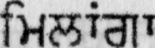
ਮਿਲਾਂਗਾ
